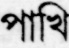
পাখি
